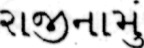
રાજીનામું
